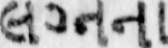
લગ્નના
